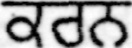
ਕਰਨ
